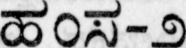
ಹಂಸ-೨
